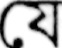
যে
